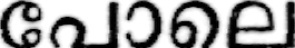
പോലെ
